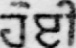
ਹੋਈ
